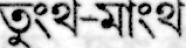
তুংথ-মাংথ
